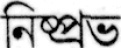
নিষ্প্ৰভ
